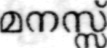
മനസ്സ്
